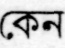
কেন
